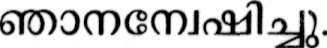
ഞാനന്വേഷിച്ചു.
